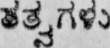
ತತ್ವಗಳು
